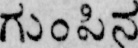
ಗುಂಪಿನ
